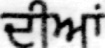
ਦੀਆਂ
